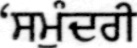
'ਸਮੁੰਦਰੀ
